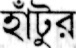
হাঁটুর
